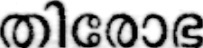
തിരോഭ
